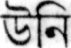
উনি
